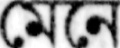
মেনে
